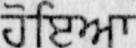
ਹੋਇਆ
